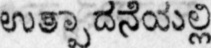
ಉತ್ಪಾದನೆಯಲ್ಲಿ
